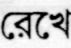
রেখে
